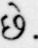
છે.
